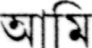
আমি
